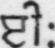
ਈ:
